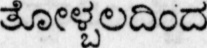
ತೋಳ್ಬಲದಿಂದ
